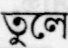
তুলে
